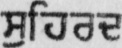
ਸੁਹਿਰਦ
